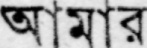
আমার
